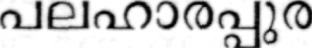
പലഹാരപ്പുര
